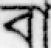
বা
